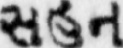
સહન
